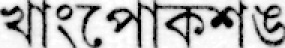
খাংপোকশঙ
